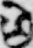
છે
